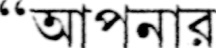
“আপনার
